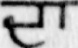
ਦਾ
